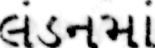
લંડનમાં
